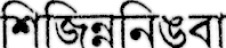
শিজিন্ননিঙবা
